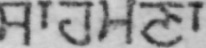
ਸਾਹਮਣਾ
